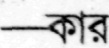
–কার
